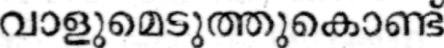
വാളുമെടുത്തുകൊണ്ട്
